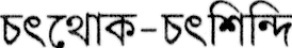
চৎথোক-চৎশিন্দি
